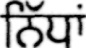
ਨਿੱਧਾਂ
